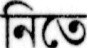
নিতে
